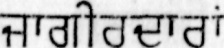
ਜਾਗੀਰਦਾਰਾਂ
